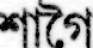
শাগৈ
